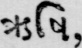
ઋષિ,
